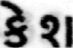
કેશ
